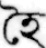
হৈ
